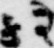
કરે
